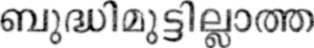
ബുദ്ധിമുട്ടില്ലാത്ത
